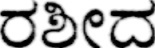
ರಶೀದ
